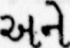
અને
